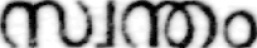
സ്വന്തം
